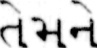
તેમને
